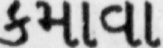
કમાવા
